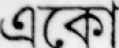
একো
